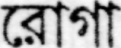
রোগা
